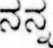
ನನ್ನ
